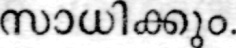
സാധിക്കും.
